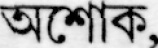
অশোক,
